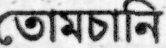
তোমচানি
